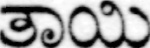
ತಾಯಿ
